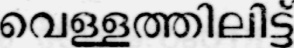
വെള്ളത്തിലിട്ട്
